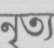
নৃত্য
